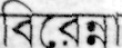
বিরেন্না
